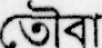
তৌবা
